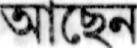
আছেন
